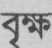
বৃক্ষ
